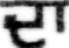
ਦਾ
